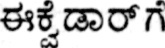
ಈಕ್ವೆಡಾರ್ಗೆ
